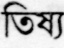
তিষ্য
